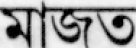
মাজত
